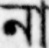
না
